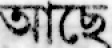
আছে
